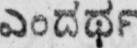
ಎಂದರ್ಥ
